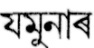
যমুনাৰ
